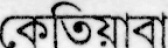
কেতিয়াবা
